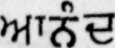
ਆਨੰਦ
